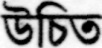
উচিত
